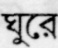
ঘুরে
